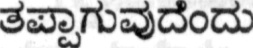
ತಪ್ಪಾಗುವುದೆಂದು
